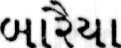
બારૈયા
